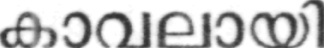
കാവലായി
